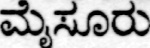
ಮೈಸೂರು
